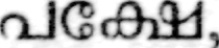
പക്ഷേ,
